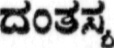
ದಂತಸ್ಯ
